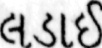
લડાઈ
